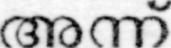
അന്ന്
